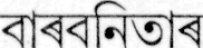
বাৰবনিতাৰ
